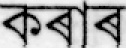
কৰাৰ
